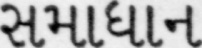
સમાધાન
